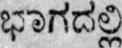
ಭಾಗದಲ್ಲಿ
